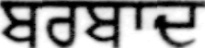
ਬਰਬਾਦ
